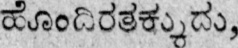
ಹೊಂದಿರತಕ್ಕುದು,
